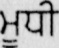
ਮੂਧੀ
